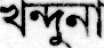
খন্দুনা
